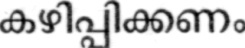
കഴിപ്പിക്കണം
